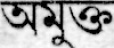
অমুক্ত
